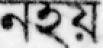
নহয়
